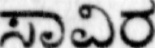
ಸಾವಿರ
